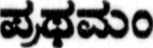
ಪ್ರಥಮ೦
